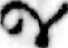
જ
